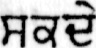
ਸਕਦੇ
